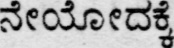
ನೇಯೋದಕ್ಕೆ
